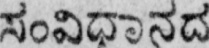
ಸಂವಿಧಾನದ
